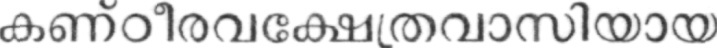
കണ്ഠീരവക്ഷേത്രവാസിയായ
